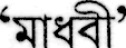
‘মাধবী’
